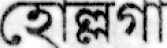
হোল্লগা
